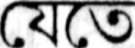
যেতে
